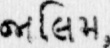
જાલિમ,
